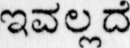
ಇವಲ್ಲದೆ
